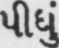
પીધું
